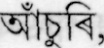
আঁচুৰি,
